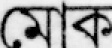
মোক
